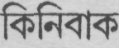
কিনিবাক
